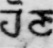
ਹੋਣ
